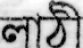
লাঠী
